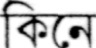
কিনে
